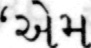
'એમ
